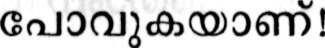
പോവുകയാണ്!
